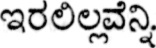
ಇರಲಿಲ್ಲವೆನ್ನಿ.
